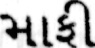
માફી
